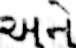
અને
